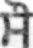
ਸੌ
